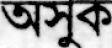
অসুক
